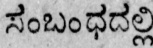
ಸಂಬಂಧದಲ್ಲಿ
